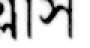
গ্লাস
